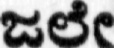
ಜಲೇ
